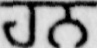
ਹਨ
